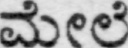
ಮೇಲೆ
